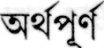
অর্থপূর্ণ
